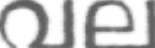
വല
